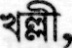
খল্লী,
